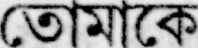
তোমাকে
